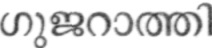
ഗുജറാത്തി
